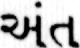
અંત
